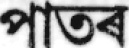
পাতৰ
